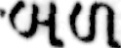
બળ
